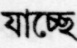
যাচ্ছে
